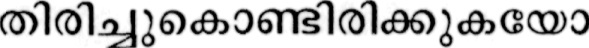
തിരിച്ചുകൊണ്ടിരിക്കുകയോ
